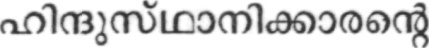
ഹിന്ദുസ്ഥാനിക്കാരന്റെ
